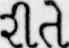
રીતે
